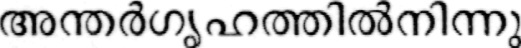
അന്തര്‍ഗൃഹത്തില്‍നിന്നു
